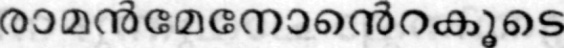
രാമന്‍മേനോന്റെകൂടെ
